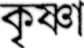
কৃষ্ণা
